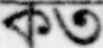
কত
